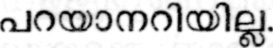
പറയാനറിയില്ല.
